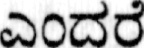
ಎಂದರೆ
